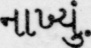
નાખ્યું.
